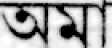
অমা
